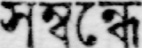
সম্বন্ধে
